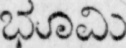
ಭೂಮಿ
